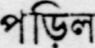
পড়িল
